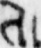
તો
